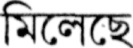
মিলেছে
